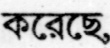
করেছে,
